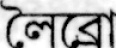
লৈব্রা
